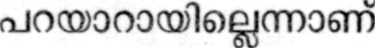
പറയാറായില്ലെന്നാണ്
